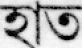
হাত
